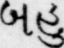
બહુ
